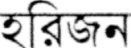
হরিজন
